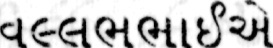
વલ્લભભાઈએ
